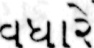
વધારે
